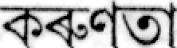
কৰুণতা
